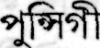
পু্ন্সিগী
